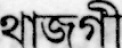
থাজগী
